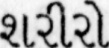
શરીરો
